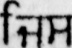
ਜਿਸ
